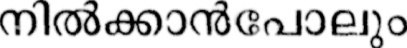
നില്‍ക്കാന്‍പോലും
